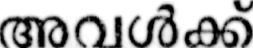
അവള്‍ക്ക്
